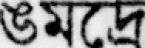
ঙমদ্রে
